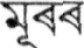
মূৰৰ
